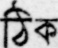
ঠিক
